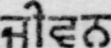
ਜੀਵਨ
